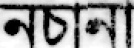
নচানা
